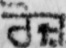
ਰੋਜ਼
